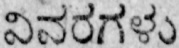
ವಿವರಗಳು
